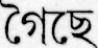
গৈছে
